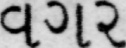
વગર
